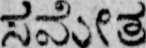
ಸಮೇತ
